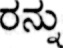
ರನ್ನು
